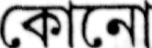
কোনো
